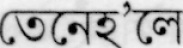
তেনেহ'লে
